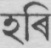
হৰি
